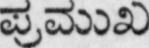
ಪ್ರಮುಖ
